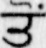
ਤੋਂ
